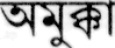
অমুক্কা
